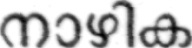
നാഴിക
